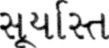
સૂર્યાસ્ત
